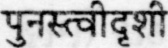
पुनस्त्वीदृशी
